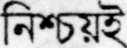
নিশ্চয়ই
